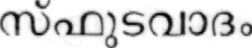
സ്ഫുടവാദം
